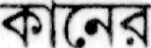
কানের
